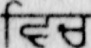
ਵਿਚ
